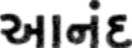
આનંદ
